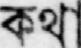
কথা
